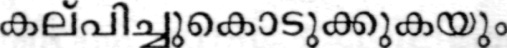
കല്പിച്ചുകൊടുക്കുകയും
